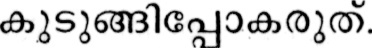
കുടുങ്ങിപ്പോകരുത്.
